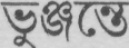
ভুঞ্জন্তে
